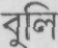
বুলি
